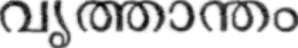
വൃത്താന്തം
